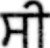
ਸੀ
